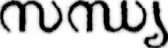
സന്ധ്യ
